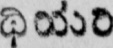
ಥಿಯರಿ
